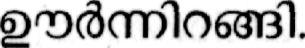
ഊര്‍ന്നിറങ്ങി.
